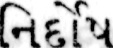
નિર્દોષ
